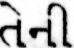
તેની
